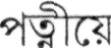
পত্নীয়ে
